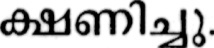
ക്ഷണിച്ചു.
